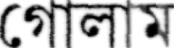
গোলাম
